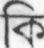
কি
